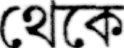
থেকে
